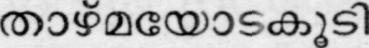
താഴ്മയോടകൂടി
